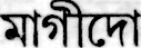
মাগীদো
